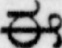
ಈ
